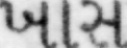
ખાસ
